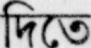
দিতে
